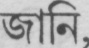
জানি,
